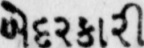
બેદરકારી
